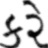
કરે
